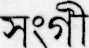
সংগী
